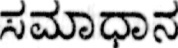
ಸಮಾಧಾನ
